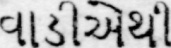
વાડીએથી
